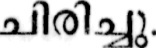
ചിരിച്ചു.
